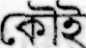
কৌই
